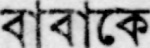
বাবাকে
